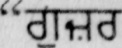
''ਗੁਜ਼ਰ
